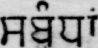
ਸਬੰਧਾਂ
